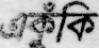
একুঁকি
